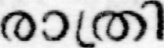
രാത്രി
